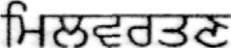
ਮਿਲਵਰਤਣ
